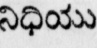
ನಿಧಿಯು
